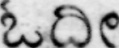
ಓದೀ
